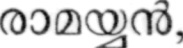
രാമയ്യന്‍,
